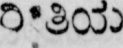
ರೀತಿಯ
